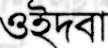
ওইদবা
